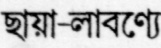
ছায়া-লাবণ্যে
